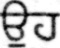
ਉਹ
